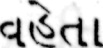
વહેતા
